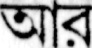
আর
